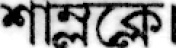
শাম্লক্লে।
